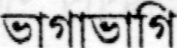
ভাগাভাগি
